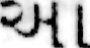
આ
